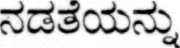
ನಡತೆಯನ್ನು
